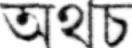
অথচ
